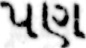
પણ
